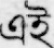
এই
